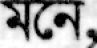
মনে,
